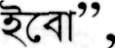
ইবো”,
